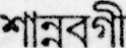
শান্নবগী
